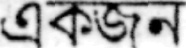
একজন
